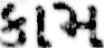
કામ
